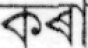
কৰা
